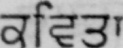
ਕਵਿਤਾ
